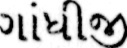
ગાંધીજી
